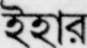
ইহার
